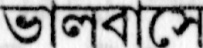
ভালবাসে
